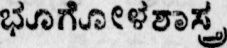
ಭೂಗೋಳಶಾಸ್ತ್ರ
